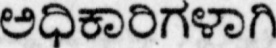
ಅಧಿಕಾರಿಗಳಾಗಿ
